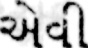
એવી
